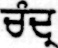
ਚੰਦ੍ਰ
